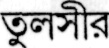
তুলসীর
